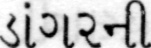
ડાંગરની
